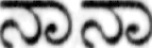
ನಾನಾ
